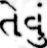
તેવું
